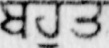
ਬਹੁਤ
